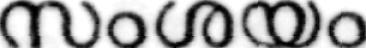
സംശയം
